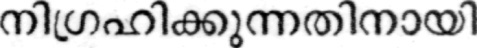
നിഗ്രഹിക്കുന്നതിനായി
